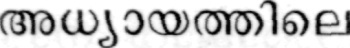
അധ്യായത്തിലെ
